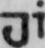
ਹਾਂ
